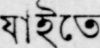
যাইতে
